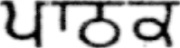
ਪਾਠਕ
